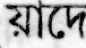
য়াদে
